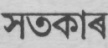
সতকাৰ
